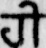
ਹੀ
